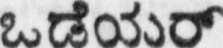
ಒಡೆಯರ್
